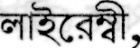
লাইরেম্বী,
